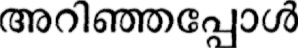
അറിഞ്ഞപ്പോള്‍
